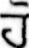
ਹੋ
